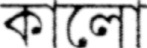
কালো
